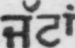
ਜੱਟਾਂ
